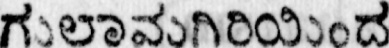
ಗುಲಾಮಗಿರಿಯಿಂದ
